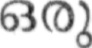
ഒരു
